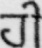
ਹੀ
